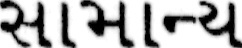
સામાન્ય
